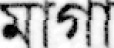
মাগা
